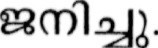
ജനിച്ചു.
